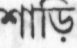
শাড়ি
